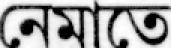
নেমাতে
